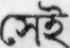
সেই
